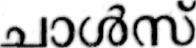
ചാള്‍സ്
